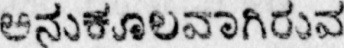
ಅನುಕೂಲವಾಗಿರುವ
